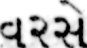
વરસે
